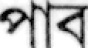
পাব
